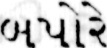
બપોરે
